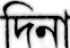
দিনা
